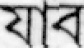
যাব
